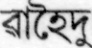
ৱাহৈদু
